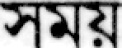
সময়
